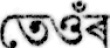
তেওঁৰ
